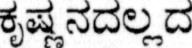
ಕೃಷ್ಣನದಲ್ಲದ
